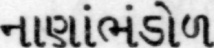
નાણાંભંડોળ
